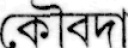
কৌবদা
